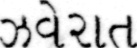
ઝવેરાત
